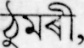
ঠুমৰী,
